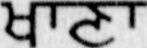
ਖਾਣਾ
